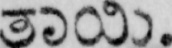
ತಾಯಿ.
